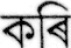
কৰি
